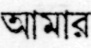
আমার
